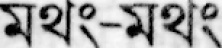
মথং-মথং
